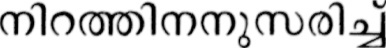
നിറത്തിനനുസരിച്ച്
